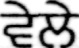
ਵੇਲੇ
